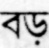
বড়
